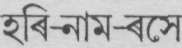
হৰি-নাম-ৰসে
